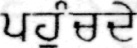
ਪਹੁੰਚਦੇ
